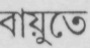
বায়ুতে
